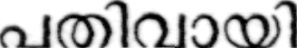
പതിവായി
